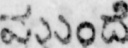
ಮುಂದೆ
